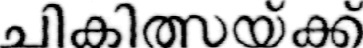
ചികിത്സയ്ക്ക്
